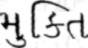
મુક્તિ
